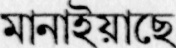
মানাইয়াছে
